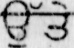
ਉੱਤੇ
